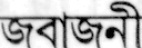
জবাজনী
